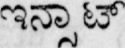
ಇನ್ಸಾಟ್
